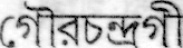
গৌরচন্দ্রগী
